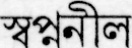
স্বপ্ননীল
